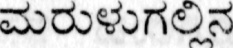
ಮರುಳುಗಲ್ಲಿನ
